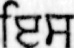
ਇਸ
